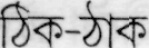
ঠিক-ঠাক
